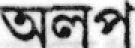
অলপ
